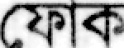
ফোক
